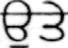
ਉਤੇ
